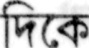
দিকে
